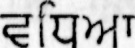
ਵਧਿਆ
